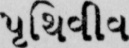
પૃથિવીવ
